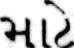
માટે
